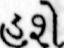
હશે
